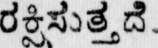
ರಕ್ಷಿಸುತ್ತದೆ.
